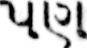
પણ
